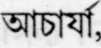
আচার্যা,
